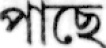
পাছে
